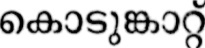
കൊടുങ്കാറ്റ്
